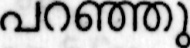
പറഞ്ഞു
